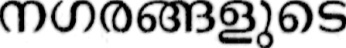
നഗരങ്ങളുടെ
